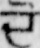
ਦੋ
